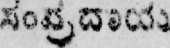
ಸಂಪ್ರದಾಯ
